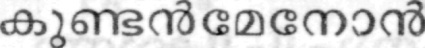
കുണ്ടന്‍മേനോന്‍
